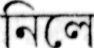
নিলে
